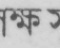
লক্ষ
